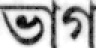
ভাগ
